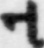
ન
